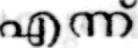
എന്ന്
